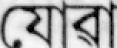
যোৱা
